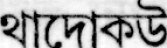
থাদোকউ
